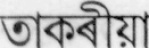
তাকৰীয়া
